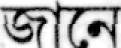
জানে
